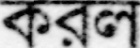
করল
